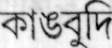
কাঙবুদি
